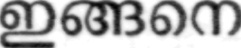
ഇങ്ങനെ
